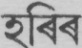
হৰিৰ
